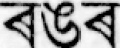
ৰঙৰ
